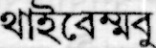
থাইবেম্মবু
